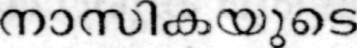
നാസികയുടെ
